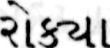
રોક્યા
